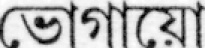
ভোগায়ো
